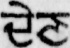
ਦੇਣ
